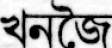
খনজৈ
